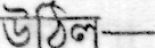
উঠিল-
